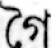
গৈ
